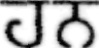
ਹਨ
